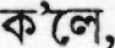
ক'লে,
